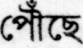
পৌঁছে
